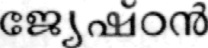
ജ്യേഷ്ഠന്‍
